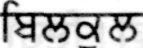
ਬਿਲਕੁਲ
